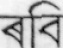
ৰবি
